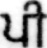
ਪੀ
